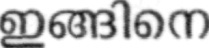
ഇങ്ങിനെ
